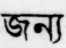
জন্য
